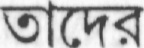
তাদের
